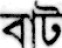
বাট
